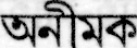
অনীমক
